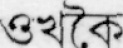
ওখকৈ
